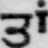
ਤਾਂ
